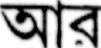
আর
